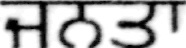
ਜਨਤਾ
